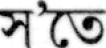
স'তে
